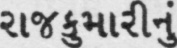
રાજકુમારીનું
